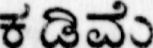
ಕಡಿಮೆ
